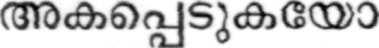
അകപ്പെടുകയോ
